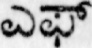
ಎಫ್
